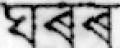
ঘৰৰ
